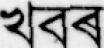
খবৰ
